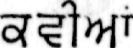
ਕਵੀਆਂ
